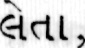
લેતા,
